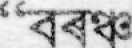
"বৰঞ্চ
